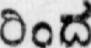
ರಿಂದ
